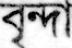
বৃন্দা
